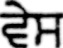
ਵੇਸ
